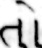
તો
